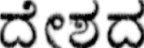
ದೇಶದ
